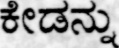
ಕೇಡನ್ನು
